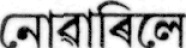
নোৱাৰিলে
